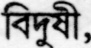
বিদুষী,
